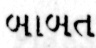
બાબત
